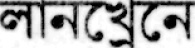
লানখ্রেনে
